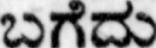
ಬಗೆದು
